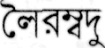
লৈরম্বদু
